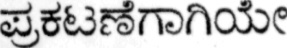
ಪ್ರಕಟಣೆಗಾಗಿಯೇ
